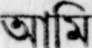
আমি
